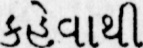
કહેવાથી
